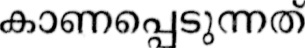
കാണപ്പെടുന്നത്
